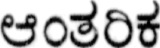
ಆಂತರಿಕ
